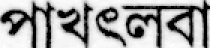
পাখৎলবা
